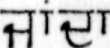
ਜਾਂਦਾ
